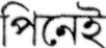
পিনেই
